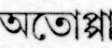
অতোপ্পা
